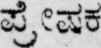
ಪ್ರೇಷಕ
